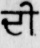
ਦੀ
